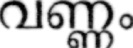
വണ്ണം
